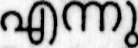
എന്നു
